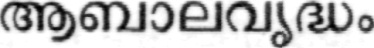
ആബാലവൃദ്ധം
